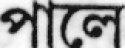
পালে
